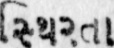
સ્થિરતા
